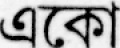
একো
